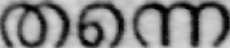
തന്നെ
